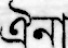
ঐনা
